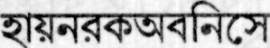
হায়নরকঅবনিসে
